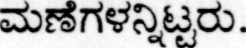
ಮಣೆಗಳನ್ನಿಟ್ಟರು.
